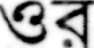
ওর
